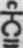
ਨੂੰ
